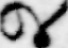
જ
